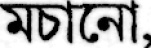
মচানো.
